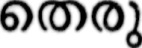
തെരു
